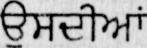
ਉਸਦੀਆਂ
